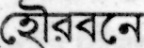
হৌরবনে
